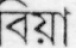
বিয়া
